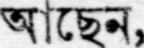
আছেন,
